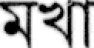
মখা
